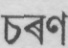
চৰণ
